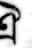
ঐ
